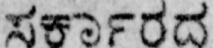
ಸರ್ಕಾರದ
